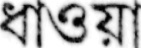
ধাওয়া
